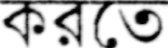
করতে
